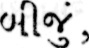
બીજું,
